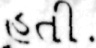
હતી.
